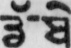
ਡੱਬੇ
